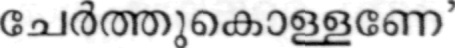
ചേര്‍ത്തുകൊള്ളണേ’
